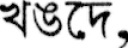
খঙদে,
